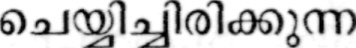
ചെയ്യിപ്പിച്ചിരിക്കുന്ന
